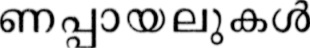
ണപ്പായലുകള്‍
